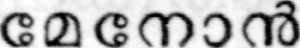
മേനോന്‍
